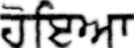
ਹੋਇਆ
